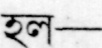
হল–
